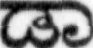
ಡಾ
